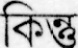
কিন্তু
